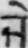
ਜੇ
